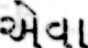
એવા
